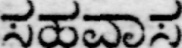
ಸಹವಾಸ
